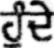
ਹੁੰਦੇ
